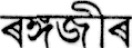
ৰঙ্গজীৰ
